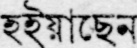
হইয়াছেন
